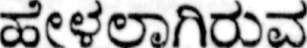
ಹೇಳಲಾಗಿರುವ
